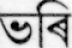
ভৰি
